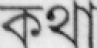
কথা
